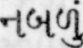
નબળું
